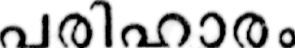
പരിഹാരം
